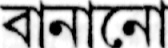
বানানো
